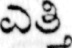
ಎತ್ತಿ
